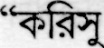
“করিসু
